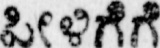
ಪೀಳಿಗೆಗೆ
